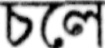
চলে
